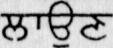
ਲਾਉਣ
